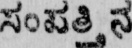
ಸಂಪತ್ತಿನ
